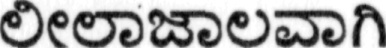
ಲೀಲಾಜಾಲವಾಗಿ
